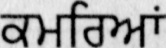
ਕਮਰਿਆਂ
